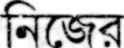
নিজের
